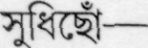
সুধিছোঁ-
